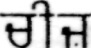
ਚੀਜ਼
